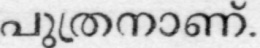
പുത്രനാണ്.
